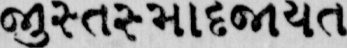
જુસ્તસ્માદજાયત
